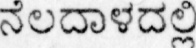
ನೆಲದಾಳದಲ್ಲಿ
